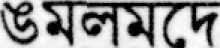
ঙমলমদে
